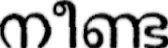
നീണ്ട
